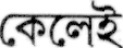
কেলেই
